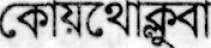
কোয়থোক্লুবা
